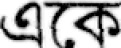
একে
